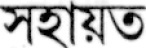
সহায়ত
